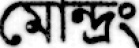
মোন্দ্রং
